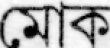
মোক
